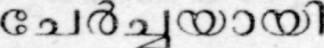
ചേര്‍ച്ചയായി
